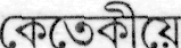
কেতেকীয়ে
